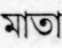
মাতা
